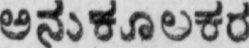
ಅನುಕೂಲಕರ
